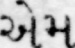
એમ
